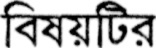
বিষয়টির
